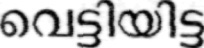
വെട്ടിയിട്ട
